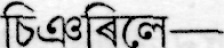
চিঞৰিলে-
